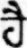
ਹੈ
